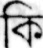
কি
